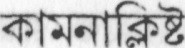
কামনাক্লিষ্ট
